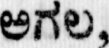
ಅಗಲ,
